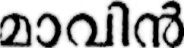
മാവിന്‍
